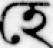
হে
